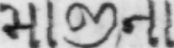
માજીના
